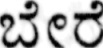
ಬೇರೆ
